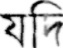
যদি
